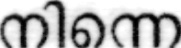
നിന്നെ
